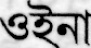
ওইনা
